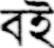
বই
